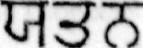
ਯਤਨ
